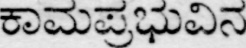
ಕಾಮಪ್ರಭುವಿನ
